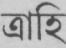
ত্ৰাহি
